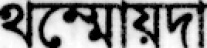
থম্মোয়দা
